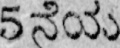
5ನೆಯ
